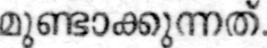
മുണ്ടാക്കുന്നത്.
